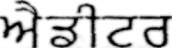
ਐਡੀਟਰ
